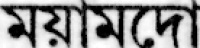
ময়ামদো
